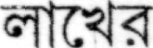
লাখের
